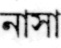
নাসা
